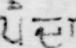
ਪੈਦਾ
